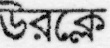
উরক্লে
